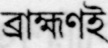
ব্রাহ্মণই
